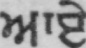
ਆਏ
